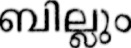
ബില്ലും
